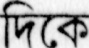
দিকে
